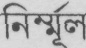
নিৰ্ম্মূল
